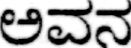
ಅವನ
